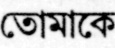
তোমাকে
